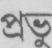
প্ৰভু
